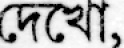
দেখো,
